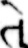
તે
